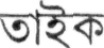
তাইক
